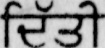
ਦਿੱਤੀ
